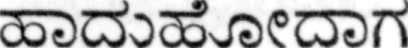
ಹಾದುಹೋದಾಗ
